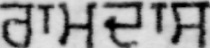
ਰਾਮਦਾਸ
